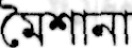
মৈশানা
